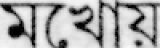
মখোয়
